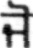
ਜੋ
